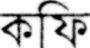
কফি
